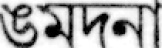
ঙমদনা
